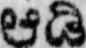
ಆಡಿ
